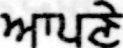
ਆਪਣੇ
